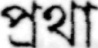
প্রথা
